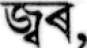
জ্বৰ,
